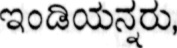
ಇಂಡಿಯನ್ನರು,
